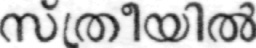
സ്ത്രീയില്‍
